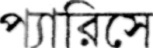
প্যারিসে
